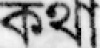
কথা
